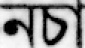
নচা
